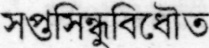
সপ্তসিন্ধুবিধৌত
